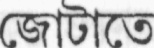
জোটাতে
